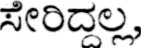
ಸೇರಿದ್ದಲ್ಲ,
